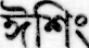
ঈশিং
